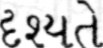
દૃશ્યતે
